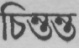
চিন্তন্ত
